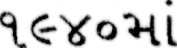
૧૯૪૦માં
